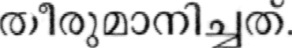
തീരുമാനിച്ചത്.
